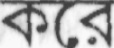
করে
